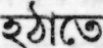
হঠাতে
